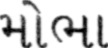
મોભા
